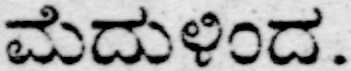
ಮೆದುಳಿಂದ.
